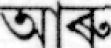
আৰু
